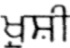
ਖ਼ੁਸ਼ੀ
